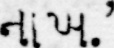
નાખ.'
